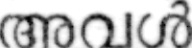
അവള്‍
